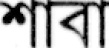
শাবা
